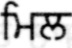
ਮਿਲ
